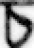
চ
